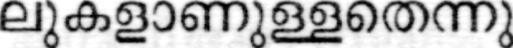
ലുകളാണുള്ളതെന്നു
